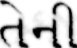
તેની
